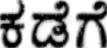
ಕಡೆಗೆ
